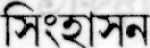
সিংহাসন
